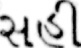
સહી
